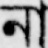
না
